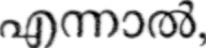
എന്നാല്‍,
